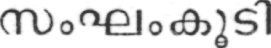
സംഘംകൂടി
